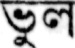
ভুল
